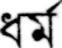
ধর্ম
